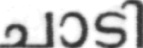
ചാടി
